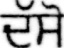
ਦੱਸੋ
